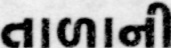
તાળાની
